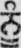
ਨੂੰ
